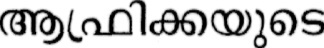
ആഫ്രിക്കയുടെ
